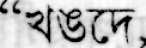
“খঙদে,
